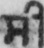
ਸੀ
